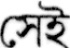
সেই
